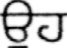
ਉਹ
